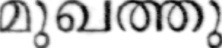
മുഖത്തു
